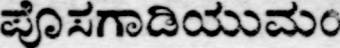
ಪೊಸಗಾಡಿಯುಮಂ
